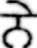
ਨੇ
